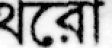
থরো
